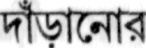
দাঁড়ানোর
